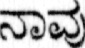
ನಾವು
